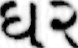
ઘર
